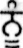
ਨੂੰ
